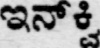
ಇನ್‌ಕ್ವಿ
